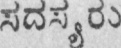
ಸದಸ್ಯರು
